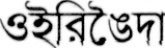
ওইরিঙৈদা
